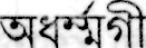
অধর্ম্মগী
